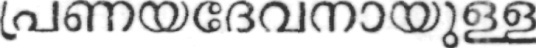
പ്രണയദേവനായുള്ള
